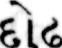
દોઢ
